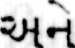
અને
